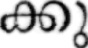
ക്കു
